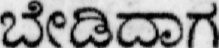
ಬೇಡಿದಾಗ
